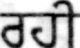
ਰਹੀ
